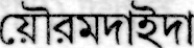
য়ৌরমদাইদা
